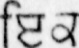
ਇਕ
